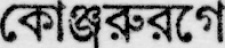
কোঞ্জরুরগে
